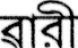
ৱারী
